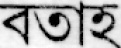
বতাহ
